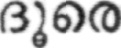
ദൂരെ
